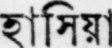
হাসিয়া
